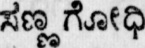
ಸಣ್ಣಗೋಧಿ
